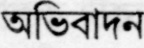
অভিবাদন
